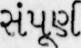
સંપૂર્ણ
